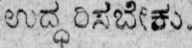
ಉದ್ಧರಿಸಬೇಕು.
